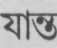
যান্ত
